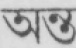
অন্ত
